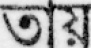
তায়
